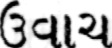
ઉવાચ
